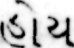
હોય
